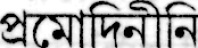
প্রমোদিনীনি
